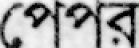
পেপর
